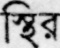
স্থির
